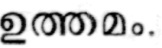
ഉത്തമം.
